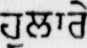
ਹੁਲਾਰੇ
